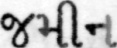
જમીન
